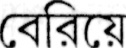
বেরিয়ে
